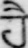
ਹੈ
